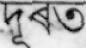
দূৰত
